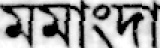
মমাংদা
